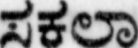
ಸಕಲಾ
